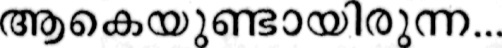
ആകെയുണ്ടായിരുന്ന...
